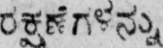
ರಕ್ಷಣೆಗಳನ್ನು
